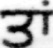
ਤਾਂ
